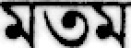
মতম
